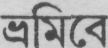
ভ্ৰমিবে
